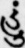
હુ
